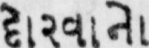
દોરવાનો
